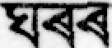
ঘৰৰ
